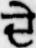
ਦੇ
